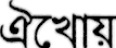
ঐখোয়
